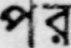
পর
